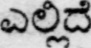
ಎಲ್ಲಿದೆ
